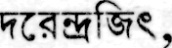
দরেন্দ্রজিৎ,
